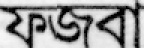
ফজবা
